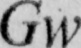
Gw
